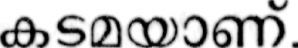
കടമയാണ്.
